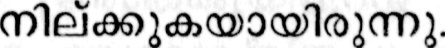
നില്ക്കുകയായിരുന്നു.
